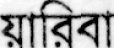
য়ারিবা
